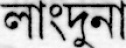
লাংদুনা
